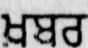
ਖ਼ਬਰ
